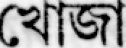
খোজা
